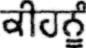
ਕੀਹਨੂੰ
